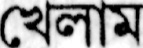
খেলাম
